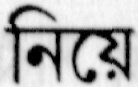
নিয়ে
